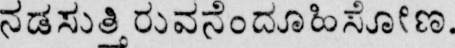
ನಡಸುತ್ತಿರುವನೆಂದೂಹಿಸೋಣ.
